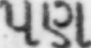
પણ
